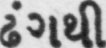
ઢંગથી
